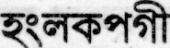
হংলকপগী
